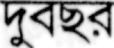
দুবছর
